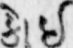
કોઈ
